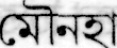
মৌনহা
